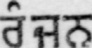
ਰੰਜਨ
